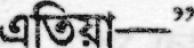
এতিয়া-"
